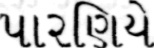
પારણિયે
